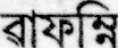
ৱাফম্নি
